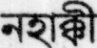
নহাক্কী
